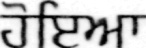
ਹੋਇਆ
